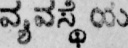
ವ್ಯವಸ್ಥೆಯ
